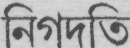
নিগদতি
